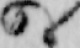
જ
